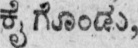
ಕೈಗೊಂಡು,
